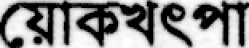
য়োকখৎপা
